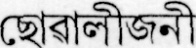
ছোৱালীজনী
